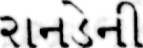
રાનડેની
